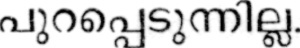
പുറപ്പെടുന്നില്ല.
